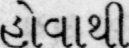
હોવાથી
